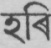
হৰি
